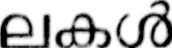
ലകള്‍
